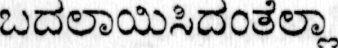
ಬದಲಾಯಿಸಿದಂತೆಲ್ಲಾ
